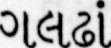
ગલઢાં
